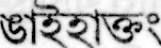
ঙাইহাক্তং
